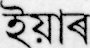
ইয়াৰ
